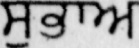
ਸੁਭਾਅ
